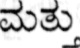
ಮತ್ತು
